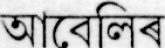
আবেলিৰ
